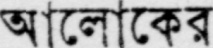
আলোকের
